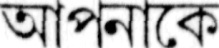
আপনাকে
